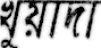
খুয়াদা
